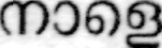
നാളെ
